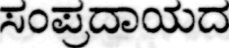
ಸಂಪ್ರದಾಯದ
